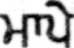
ਮਾਪੇ
